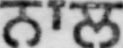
ਨਾਲ
